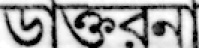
ডাক্তরনৱা
